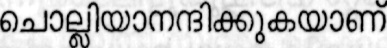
ചൊല്ലിയാനന്ദിക്കുകയാണ്
